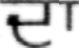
ਦਾ
